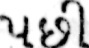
પછી
